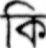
কি
